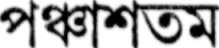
পঞ্চাশতম
